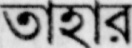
তাহার
